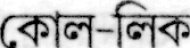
কোল-লিক
